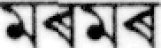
মৰমৰ
